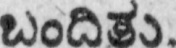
ಬಂದಿತು.
